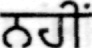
ਨਹੀਂ
